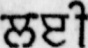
ਲਈ
